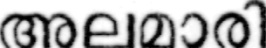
അലമാരി
